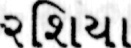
રશિયા
